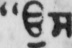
''ਉਸ
